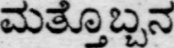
ಮತ್ತೊಬ್ಪನ
